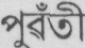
পুৱঁতী
